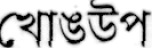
খোঙউপ
